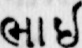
ભાઈ
